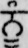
ਨੂੰ
